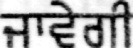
ਜਾਵੇਗੀ
